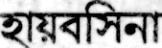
হায়বসিনা
